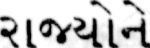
રાજ્યોને
